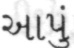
આપું
